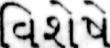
વિશેષે
